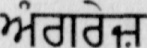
ਅੰਗਰੇਜ਼
